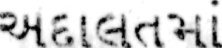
અદાલતમાં
